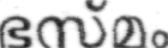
ഭസ്മം
